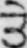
ਤੇ
